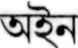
অইন
